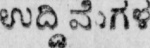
ಉದ್ದಿಮೆಗಳ
